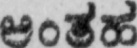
ಅಂತಹ
